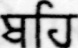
ਬਹਿ
